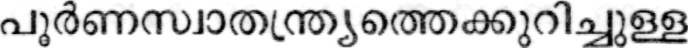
പൂര്‍ണസ്വാതന്ത്ര്യത്തെക്കുറിച്ചുള്ള
